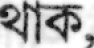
থাক,
